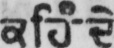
ਕਹਿੰਦੇ
